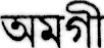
অমগী
